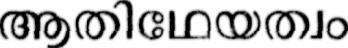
ആതിഥേയത്വം
